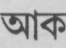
আক
